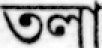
তলা
